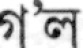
গ'ল
